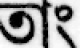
তাং
